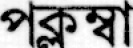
পক্লম্বা
